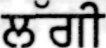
ਲੱਗੀ
